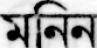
মনিন
